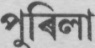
পুৰিলা
